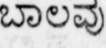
ಬಾಲವು
